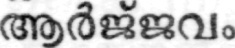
ആര്‍ജ്ജവം
